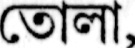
তোলা,
